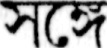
সঙ্গে
